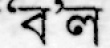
"ব'ল
